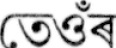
তেওঁৰ
